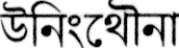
উনিংথৌনা
